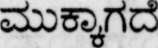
ಮುಕ್ಕಾಗದೆ
